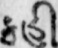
કહી
